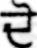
ਦੋ
